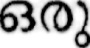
ഒരു
